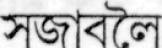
সজাবলৈ
